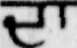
ਦਾ
